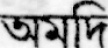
অমদি
